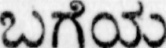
ಬಗೆಯ
